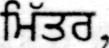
ਮਿੱਤਰ,
